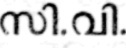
സി.വി.
